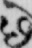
છે
